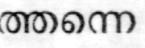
ത്തന്നെ
